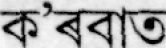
ক'ৰবাত
